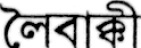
লৈবাক্কী
